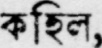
কহিল,
